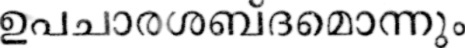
ഉപചാരശബ്ദമൊന്നും
